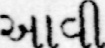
આવી
